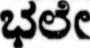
ಭಲೇ
